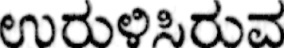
ಉರುಳಿಸಿರುವ
